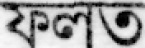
ফলত
